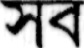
সব
